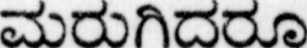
ಮರುಗಿದರೂ
